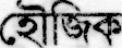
হৌজিক
